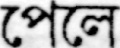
পেলে
